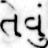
તેવું
